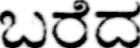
ಬರೆದ
